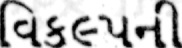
વિકલ્પની
